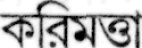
করিমত্তা
